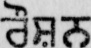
ਰੌਸ਼ਨ
